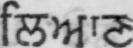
ਲਿਆਣ
